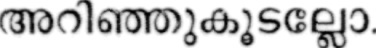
അറിഞ്ഞുകൂടല്ലോ.
